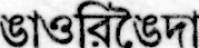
ঙাওরিঙৈদা
